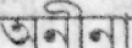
অনীনা
